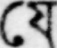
যে
